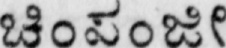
ಚಿಂಪಂಜೀ
